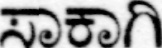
ಸಾಕಾಗಿ
